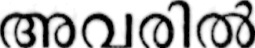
അവരില്‍
